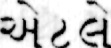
એટલે
